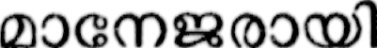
മാനേജരായി
